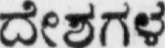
ದೇಶಗಳ
